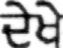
ਦੇਖੇ
